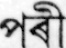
পৰী
